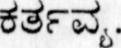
ಕರ್ತವ್ಯ.
